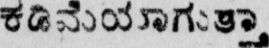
ಕಡಿಮೆಯಾಗುತ್ತಾ
